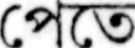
পেতে
